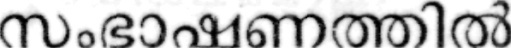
സംഭാഷണത്തില്‍
